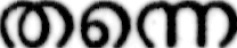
തന്നെ
